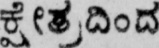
ಕ್ಷೇತ್ರದಿಂದ
